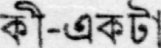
কী-একটা
